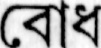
বোধ
